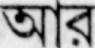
আর
